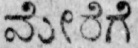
ಮೇರೆಗೆ
